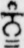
ਨੂੰ
